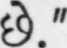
છે."
